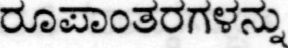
ರೂಪಾಂತರಗಳನ್ನು
